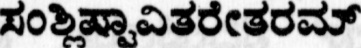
ಸಂಶ್ಲಿಷ್ಟಾವಿತರೇತರಮ್
